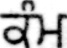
ਕੰਮ
